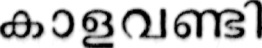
കാളവണ്ടി
